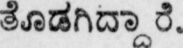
ತೊಡಗಿದ್ದಾರೆ.
